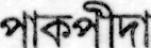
পাকপীদা
